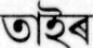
তাইৰ
